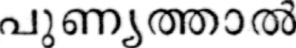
പുണ്യത്താല്‍
